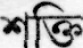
শক্তি
